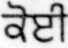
ਕੋਈ
